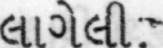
લાગેલી.
